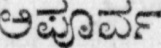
ಅಪೂರ್ವ
